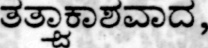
ತತ್ತ್ವಾಕಾಶವಾದ,
